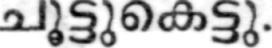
ചൂട്ടുകെട്ടു.
